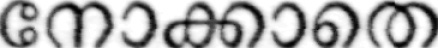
നോക്കാതെ
